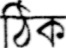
ঠিক
